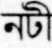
নটী
